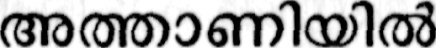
അത്താണിയില്‍
